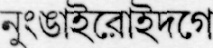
নুংঙাইরোইদগে
